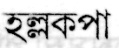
হল্লকপা
